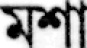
মশা
